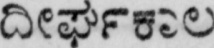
ದೀರ್ಘಕಾಲ
